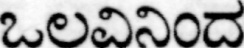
ಒಲವಿನಿಂದ
